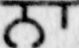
ਨਾ
